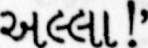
અલ્લા!'
